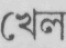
খেল
